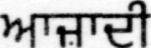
ਆਜ਼ਾਦੀ
